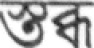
স্তব্ধ
